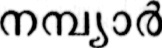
നമ്പ്യാര്‍
